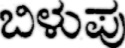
ಬಿಳುಪು
